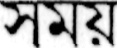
সময়
